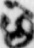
છે
